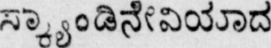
ಸ್ಕ್ಯಾಂಡಿನೇವಿಯಾದ
